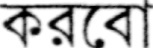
করবো
